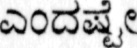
ಎಂದಷ್ಟೇ
